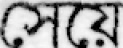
সেয়ে
